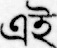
এই
